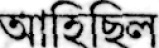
আহিছিল
